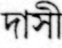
দাসী
